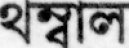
থম্বাল
